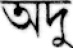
অদু
